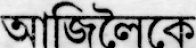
আজিলৈকে
